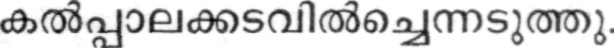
കല്‍പ്പാലക്കടവില്‍ച്ചെന്നടുത്തു.
